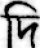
দি
